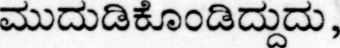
ಮುದುಡಿಕೊಂಡಿದ್ದುದು,
